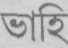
ভাহি
